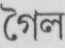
গৈল
